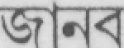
জানব
